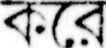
করে
